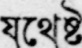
যথেষ্ট
